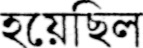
হয়েছিল
